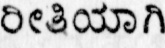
ರೀತಿಯಾಗಿ
